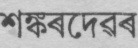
শঙ্কৰদেৱৰ
